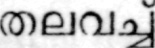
തലവച്ച്
